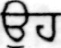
ਉਹ
